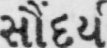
સૌંદર્ય
